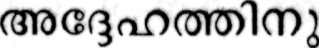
അദ്ദേഹത്തിനു
